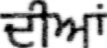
ਦੀਆਂ
